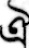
ঐ
